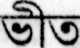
ভীত
